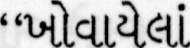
"ખોવાયેલાં
